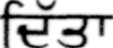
ਦਿੱਤਾ
